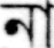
না
